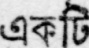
একটি
